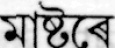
মাষ্টৰে
